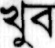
খুব
